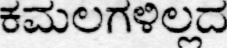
ಕಮಲಗಳಿಲ್ಲದ
